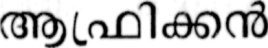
ആഫ്രിക്കന്‍
